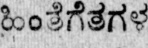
ಹಿಂತೆಗೆತಗಳ
